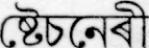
ষ্টেচনেৰী
